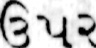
ઉપર
